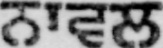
ਨਾਵਲ
